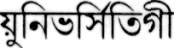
য়ুনিভর্সিতিগী
